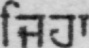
ਜਿਹਾ
